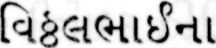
વિઠ્ઠલભાઈના
